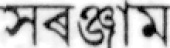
সৰঞ্জাম
